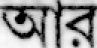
আর
